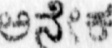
ಅನೇಕ
